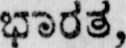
ಭಾರತ,
